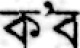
ক'ব
